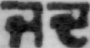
ਜਦ
